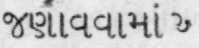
જણાવવામાં
